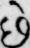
છે
